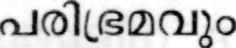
പരിഭ്രമവും
